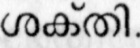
ശക്തി.
